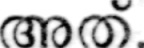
അത്.
